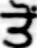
ਤੋਂ
